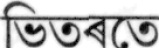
ভিতৰতে
